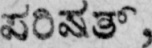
ಪರಿಷತ್,
